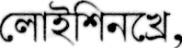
লোইশিনখ্রে,
